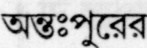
অন্তঃপুরের
